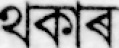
থকাৰ
